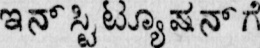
ಇನ್‌ಸ್ಟಿಟ್ಯೂಷನ್‌ಗೆ
